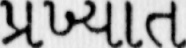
પ્રખ્યાત
